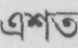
এশত
